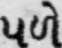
પળે
